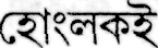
হোংলকই
